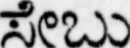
ಸೇಬು
